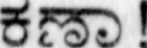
ಕಣಾ!
